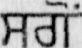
ਸਗੋਂ
